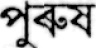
পুৰুষ
